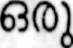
ഒരു
